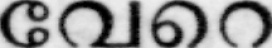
വേറെ
